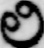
ಲಿ
